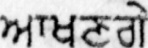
ਆਖਣਗੇ
